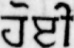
ਹੋਈ
